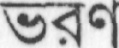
ভরণ
